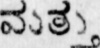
ಮತ್ತು
